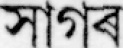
সাগৰ
